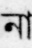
না
